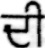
ਦੀ
